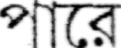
পারে
